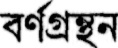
বর্ণগ্রন্থন
